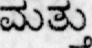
ಮತ್ತು
